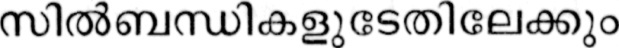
സില്‍ബന്ധികളുടേതിലേക്കും
